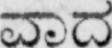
ವಾದ
